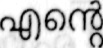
എന്റെ
